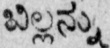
ಬಿಲ್ಲನ್ನು
